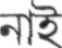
নাই
